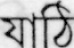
যাঠি
